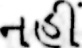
નહીં
